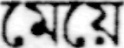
মেয়ে
